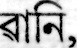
ৱানি,
